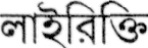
লাইরিক্তি
